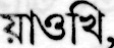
য়াওখি,
